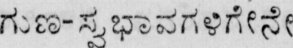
ಗುಣ-ಸ್ವಭಾವಗಳಿಗೇನೇ
